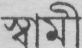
স্বামী
